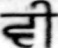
ਵੀ
